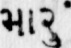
મારું
